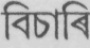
বিচাৰি
